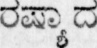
ರಷ್ಯಾದ
